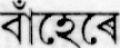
বাঁহেৰে
